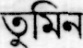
তুমিন
